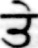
ਤੇ
